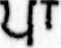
ਪਾ
